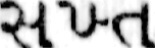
સખ્ત
